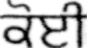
ਕੋਈ
